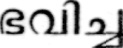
ഭവിച്ച
